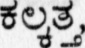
ಕಲ್ಕತ್ತ,
